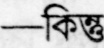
–কিন্তু
